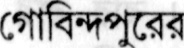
গোবিন্দপুরের
